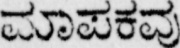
ಮಾಪಕವು
